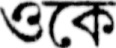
ওকে
